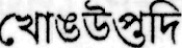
খোঙউপ্তদি
